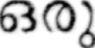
ഒരു
